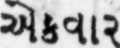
એકવાર
